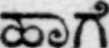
ಹಾಗೆ
